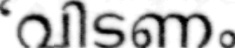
'വിടണം
